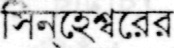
সিন্‌হেশ্বরের
